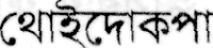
থোইদোকপা
